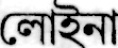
লোইনা
